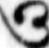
ও
